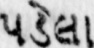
પડેલા
